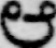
ಆ
